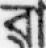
ৱা
